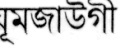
য়ূমজাউগী
